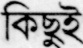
কিছুই
